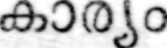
കാര്യം
